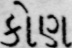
કોણ
